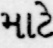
માટે
